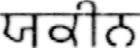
ਯਕੀਨ
